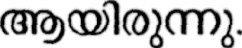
ആയിരുന്നു.
